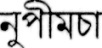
নুপীমচা
